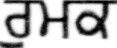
ਰੁਮਕ
